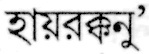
হায়রক্কনু’
